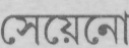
সেয়েনো
